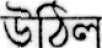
উঠিল
